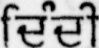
ਦਿੰਦੀ
